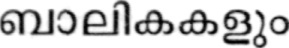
ബാലികകളും
